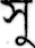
সু
